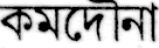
কমদৌনা
